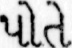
પોતે
